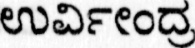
ಉರ್ವೀಂದ್ರ
